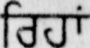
ਰਿਹਾਂ
